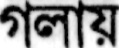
গলায়
